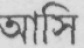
আসি
